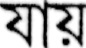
যায়
